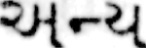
અન્ય
